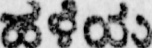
ಹಳೆಯ
